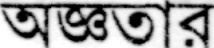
অজ্ঞতার
